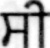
ਸੀ
